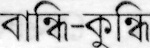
বান্ধি-কুন্ধি
